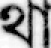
থা
